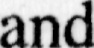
and
